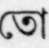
তো
